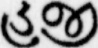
હજી
